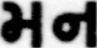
મન
